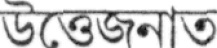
উত্তেজনাত
